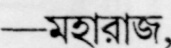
–মহারাজ,
